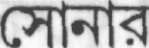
সোনার
